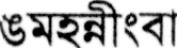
ঙমহন্নীংবা
